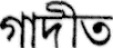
গাদীত
